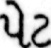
પેટ
